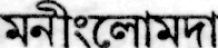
মনীংলোমদা
